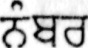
ਨੰਬਰ
